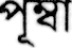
পূম্বা
